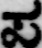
ಪ
